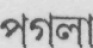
পগলা
